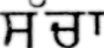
ਸੱਚਾ
